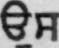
ਉਸ
